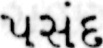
પસંદ
